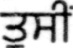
ਤੁਸੀਂ
